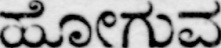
ಹೋಗುವ
